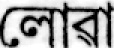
লোৱা
